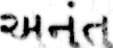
અનંત
